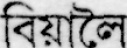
বিয়ালৈ
